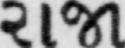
રાજા
